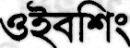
ওইবশিং
